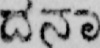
ದನಾ
